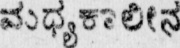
ಮಧ್ಯಕಾಲೀನ
